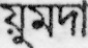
য়ুমদা
